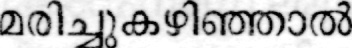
മരിച്ചുകഴിഞ്ഞാല്‍
